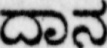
ದಾನ
